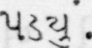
પડ્યું.
